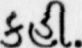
કહી.
